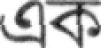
এক
